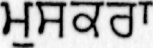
ਮੁਸਕਰਾ
